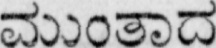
ಮುಂತಾದ
